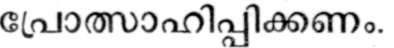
പ്രോത്സാഹിപ്പിക്കണം.
